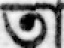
তা
